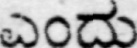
ಎಂದು
